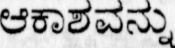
ಆಕಾಶವನ್ನು
